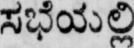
ಸಭೆಯಲ್ಲಿ
